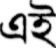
এই
